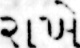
રાખે
